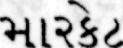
મારકેટ
